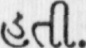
હતી.
